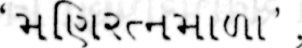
'મણિરત્નમાળા',
